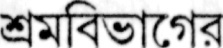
শ্রমবিভাগের
